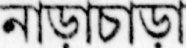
নাড়াচাড়া
